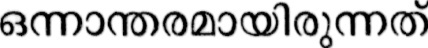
ഒന്നാന്തരമായിരുന്നത്
